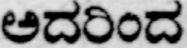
ಅದರಿಂದ
